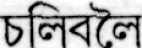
চলিবলৈ
